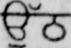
ਉੱਠ
